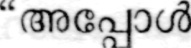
“അപ്പോള്‍
